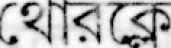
থোরক্লে
